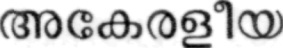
അകേരളീയ
